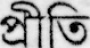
প্রীতি
